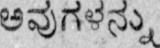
ಅವುಗಳನ್ನು
